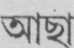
আছা
